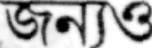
জন্যও
